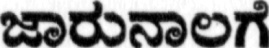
ಜಾರುನಾಲಗೆ
